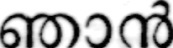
ഞാന്‍
